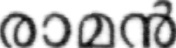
രാമന്‍
